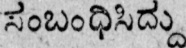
ಸಂಬಂಧಿಸಿದ್ದು
